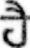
ਹੈ
